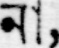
না,
